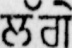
ਲੱਗੇ
